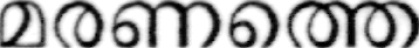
മരണത്തെ
